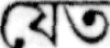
যেত
